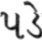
પડે
